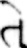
તે
